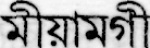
মীয়ামগী
